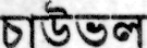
চাউভল
